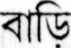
বাড়ি
